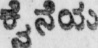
ಕ್ವೆನೆಯ
